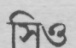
সিও
